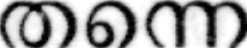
തന്നെ
